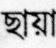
ছায়া
